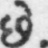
છે.
